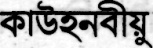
কাউহনবীয়ু
